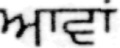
ਆਵਾਂ
